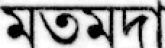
মতমদা
